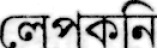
লেপকনি
